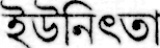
ইউনিৎতা
